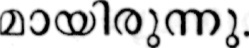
മായിരുന്നു.
